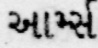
આર્મ્સ
